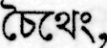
চৈথেং,
